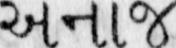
અનાજ
